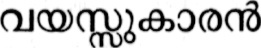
വയസ്സുകാരന്‍
